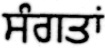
ਸੰਗਤਾਂ
